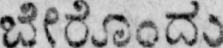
ಬೇರೊಂದು
